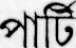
পাৰ্টি
